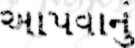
આપવાનું
